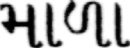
માળા
